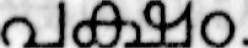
പക്ഷം.
